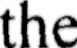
the
